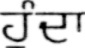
ਹੁੰਦਾ
